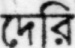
দেরি
